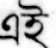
এই
